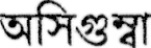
অসিগুম্বা
